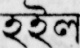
হইল
